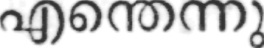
എന്തെന്നു
